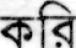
করি
